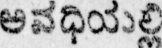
ಅವಧಿಯಲ್ಲಿ
